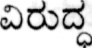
ವಿರುದ್ಧ
